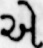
એ
